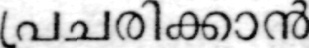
പ്രചരിക്കാന്‍
